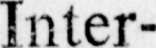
Inter-
